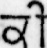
ਕੀ
